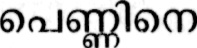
പെണ്ണിനെ
